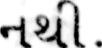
નથી.
